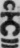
ਨੂੰ
